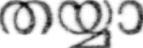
തയ്യാ
